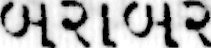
બરાબર
